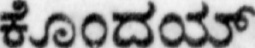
ಕೊಂದಯ್
